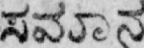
ಸಮಾನ
